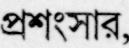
প্রশংসার,
